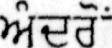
ਅੰਦਰੋਂ
